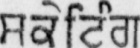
ਸਕੇਟਿੰਗ
